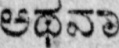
ಅಥವಾ
